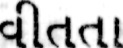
વીતતા
